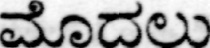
ಮೊದಲು
